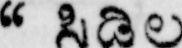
“ಸಿಡಿಲ
